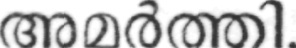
അമര്‍ത്തി.
